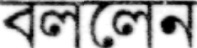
বললেন
